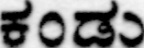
ಕಂಡು
